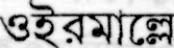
ওইরমাল্লে
